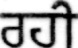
ਰਹੀ
